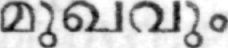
മുഖവും
